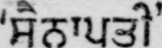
'ਸੈਨਾਪਤੀ'
